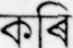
কৰি
